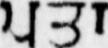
ਪਤਾ
